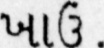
ખાઉં.
